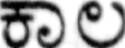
ಕಾಲ
